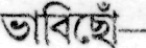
ভাবিছোঁ-
